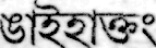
ঙাইহাক্তং
